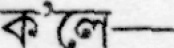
ক'লে-
